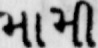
મામી
